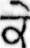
ਕੇ
